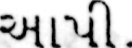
આપી.
